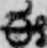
ಈ
